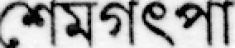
শেমগৎপা
